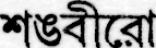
শঙবীরো
